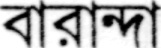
বারান্দা
